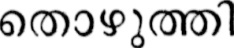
തൊഴുത്തി
